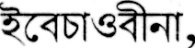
ইবেচাওবীনা
